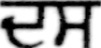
ਦਸ
